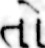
તો
